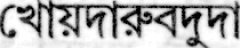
খোয়দারুবদুদা
